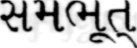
સમભૂત્
